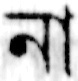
না
